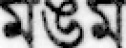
মঙম
